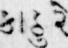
કાઠુરે
